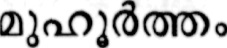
മുഹൂര്‍ത്തം
